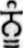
ਨੂੰ
